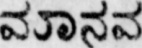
ಮಾನವ
